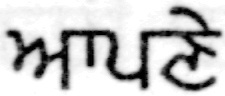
ਆਪਣੇ
